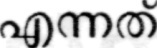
എന്നത്
